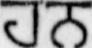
ਹਨ
